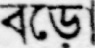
বড়ো
